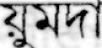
য়ুমদা
